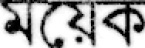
ময়েক
